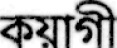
কয়াগী
